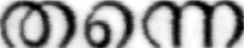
തന്നെ
